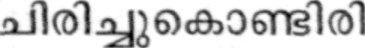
ചിരിച്ചുകൊണ്ടിരി
